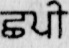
ਛਪੀ
